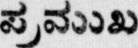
ಪ್ರಮುಖ
